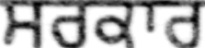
ਸਰਕਾਰ
